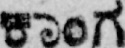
ಕಾಂಗ
